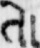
તો
